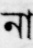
না
